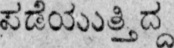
ಪಡೆಯುತ್ತಿದ್ದ
